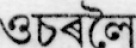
ওচৰলৈ
